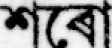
শৰো
